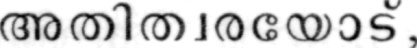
അതിത്വരയോട്,
